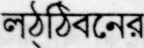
লঠ্ঠিবনের
